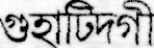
গুহাটিদগী
